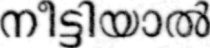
നീട്ടിയാല്‍
